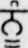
ਨੂੰ
